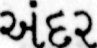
અંદર
